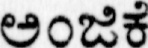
ಅಂಜಿಕೆ
